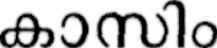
കാസിം
